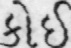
કોઈ
